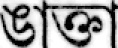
ঙাক্তা
